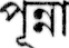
পূন্না
